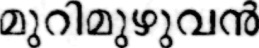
മുറിമുഴുവന്‍
